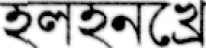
হলহনখ্রে
